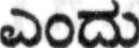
ಎಂದು
